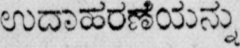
ಉದಾಹರಣೆಯನ್ನು
